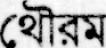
থৌরম
